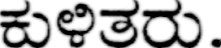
ಕುಳಿತರು.
